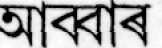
আব্বাৰ
